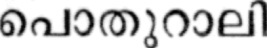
പൊതുറാലി
